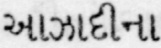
આઝાદીના
